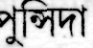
পুন্সিদা
